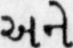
અને
